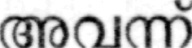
അവന്ന്
